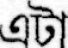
এটা
